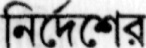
নির্দেশের
